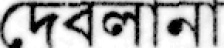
দেবলানা
